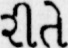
રીતે
